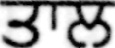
ਤਾਲ
